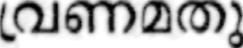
വ്രണമതു
